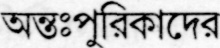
অন্তঃপুরিকাদের
